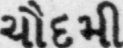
ચૌદમી
